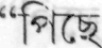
"পিছে
